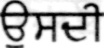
ਉਸਦੀ
